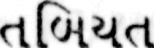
તબિયત
